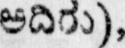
ಅದಿರು),
